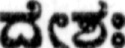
ದೇಶಃ
